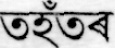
তহঁতৰ
